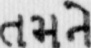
તમને
